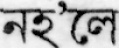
নহ'লে
